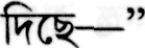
দিছে-"
